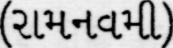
(રામનવમી)
